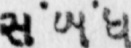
સંબંધ
